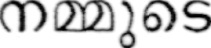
നമ്മുടെ
